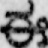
ಈ
